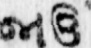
જાઉં
